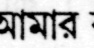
আমার
